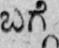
ಬಗ್ಗೆ
